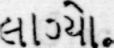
લાગ્યો.
